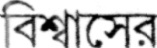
বিশ্বাসের
